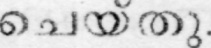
ചെയ്തു.
